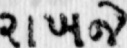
રાખજે
